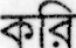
করি
